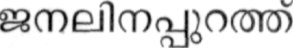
ജനലിനപ്പുറത്ത്
